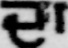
ਦਾ
